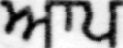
ਆਪ
